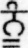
ਨੂੰ
